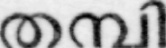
തമ്പി
